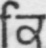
ਕਿ
